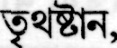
তৃথষ্টান,
